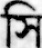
সি
